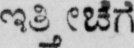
ಇತ್ತೀಚಿಗೆ
